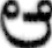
ಆ
